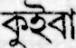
কুইবা
